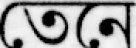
তেনে
